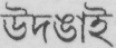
উদঙাই
